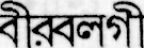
বীরবলগী
